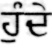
ਹੁੰਦੇ
